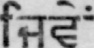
ਜਿਵੇਂ
